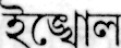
ইঙ্খোল
